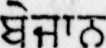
ਬੇਜਾਨ
